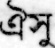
ঐসু
